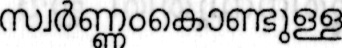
സ്വര്‍ണ്ണംകൊണ്ടുള്ള
